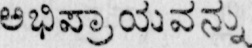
ಅಭಿಪ್ರಾಯವನ್ನು
